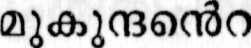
മുകുന്ദന്റെ
